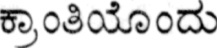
ಕ್ರಾಂತಿಯೊಂದು
